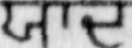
ਯਾਦ
